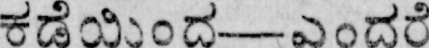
ಕಡೆಯಿಂದ-ಎಂದರೆ
